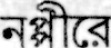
নপ্পীরে
